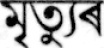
মৃত্যুৰ
